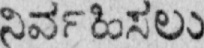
ನಿರ್ವಹಿಸಲು
